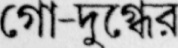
গো-দুগ্ধের
